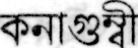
কনাগুম্বী
